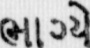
ભાગ્યે
